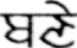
ਬਣੇ
